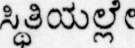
ಸ್ಥಿತಿಯಲ್ಲೇ
